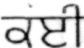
ਕਈ
